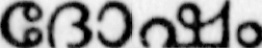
ദോഷം
